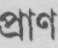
প্ৰাণ
